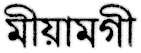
মীয়ামগী
